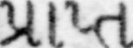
પ્રાપ્ત
